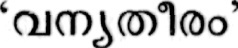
‘വന്യതീരം’
